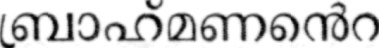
ബ്രാഹ്മണന്റെ
